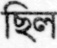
ছিল
